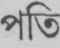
পতি
